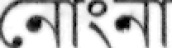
নোংনা
